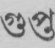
গুপ্ত
